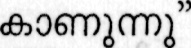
കാണുന്നു"
